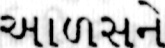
આળસને
